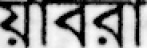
য়াবরা
